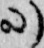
ಎ)
